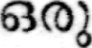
ഒരു
